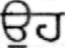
ਉਹ
